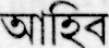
আহিব
